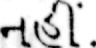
નહીં.
